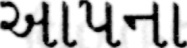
આપના
